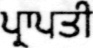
ਪ੍ਰਾਪਤੀ
